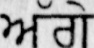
ਅੱਗੇ
